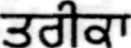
ਤਰੀਕਾ
